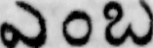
ಎಂಬ
